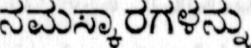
ನಮಸ್ಕಾರಗಳನ್ನು
